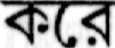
করে
